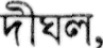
দীঘল,
